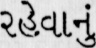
રહેવાનું
